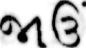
જાઉં
